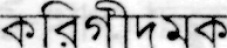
করিগীদমক
